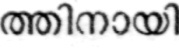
ത്തിനായി
